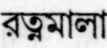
রত্নমালা
